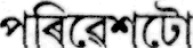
পৰিৱেশটো
